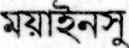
মযাইনসু
